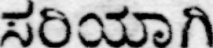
ಸರಿಯಾಗಿ
